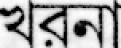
খরনা
